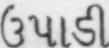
ઉપાડી
